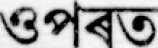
ওপৰত
